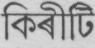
কিৰীটি
